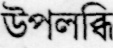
উপলব্ধি
